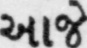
આજે
